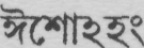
ঈশোহহং
